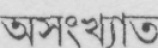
অসংখ্যাত
